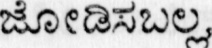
ಜೋಡಿಸಬಲ್ಲ,
